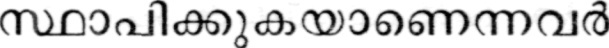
സ്ഥാപിക്കുകയാണെന്നവര്‍
